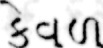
કેવળ
